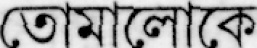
তোমালোকে
